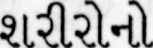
શરીરોનો
